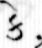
કે,
